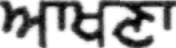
ਆਖਣਾ
